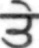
ਤੇ
